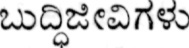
ಬುದ್ಧಿಜೀವಿಗಳು
